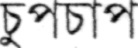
চুপচাপ
